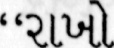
"રાખો
